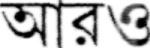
আরও
